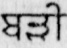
ਬੜੀ
